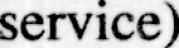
service)
